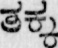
ತಕ್ಕ
